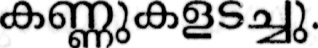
കണ്ണുകളടച്ചു.
